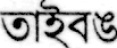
তাইবঙ
